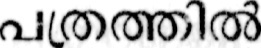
പത്രത്തില്‍
